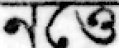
নত্তে
